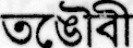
তঙৌবী
